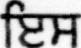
ਇਸ
